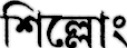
শিল্লোং
